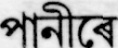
পানীৰে
